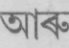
আৰু
